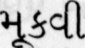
મૂકવી
